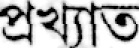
প্রখ্যাত
